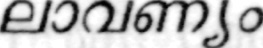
ലാവണ്യം
